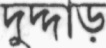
দুদ্দাড়
